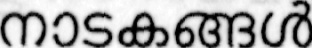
നാടകങ്ങള്‍
